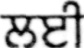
ਲਈ
